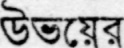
উভয়ের
